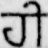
ਹੀ
